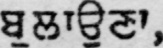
ਬੁਲਾਉਣਾ,
